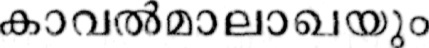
കാവല്‍മാലാഖയും
